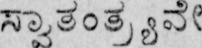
ಸ್ವಾತಂತ್ರ್ಯವೇ
